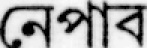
নেপাব
